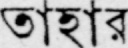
তাহার
